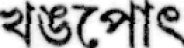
খঙপোৎ
